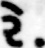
રે;
